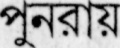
পুনরায়
